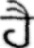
ਹੈ
